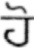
ਹੋ
